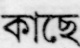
কাছে
